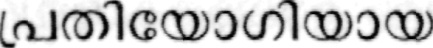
പ്രതിയോഗിയായ
